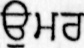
ਉਮਰ
